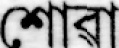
শোৱা
